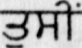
ਤੁਸੀਂ
